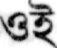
ওই
